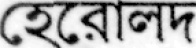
হেরোলদ
